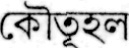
কৌতূহল
